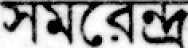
সমরেন্দ্র
